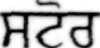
ਸਟੋਰ
